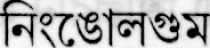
নিংঙোলগুম
